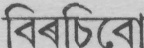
বিৰচিবো
